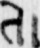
તો
